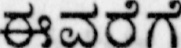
ಈವರೆಗೆ
